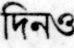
দিনও
